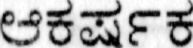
ಆಕರ್ಷಕ
